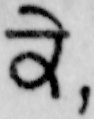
ਕੇ,
